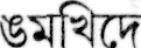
ঙমখিদে
